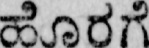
ಹೊರಗೆ
